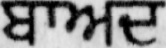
ਬਾਅਦ
